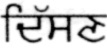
ਦਿੱਸਣ
